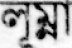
লূম্নাা
